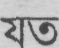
যত
